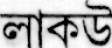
লাকউ
